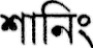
শানিং
